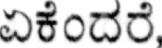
ಏಕೆಂದರೆ,
